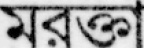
মরক্তা
